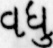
વધુ
